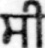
ਸੀ
